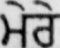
ਮੇਰੇ
